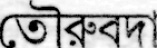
তৌরুবদা
